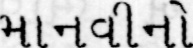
માનવીનો
